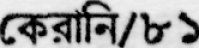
কেরানি/৮১
